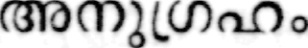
അനുഗ്രഹം
